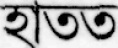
হাতত
